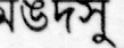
মঙদসু
